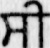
ਸੀ
